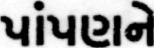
પાંપણને
